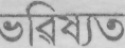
ভৱিষ্যত
